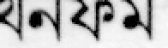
খনফম
